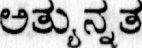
ಅತ್ಯುನ್ನತ
